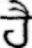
ਹੈ
